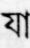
যা
